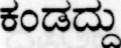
ಕಂಡದ್ದು
